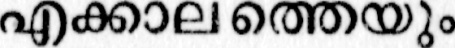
എക്കാലത്തെയും
